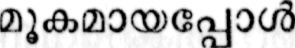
മൂകമായപ്പോള്‍
